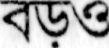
বড়ও
